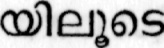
യിലൂടെ
